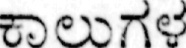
ಕಾಲುಗಳ
